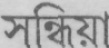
সন্ধিয়া
